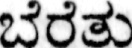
ಬೆರೆತು
